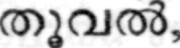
തൂവല്‍,
